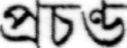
প্রচণ্ড
